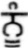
ਨੂੰ
